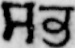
ਸਭ
